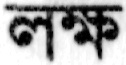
লক্ষ
